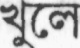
খুলে
